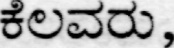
ಕೆಲವರು,
